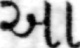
આ
